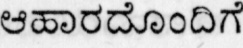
ಆಹಾರದೊಂದಿಗೆ
